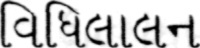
વિધિલાલન
